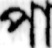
পা
